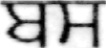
ਬਸ
